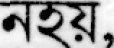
নহয়,
